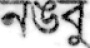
নঙবু
